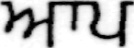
ਆਪ
